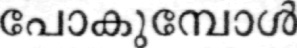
പോകുമ്പോള്‍
